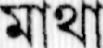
মাথা
